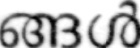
ങ്ങള്‍
